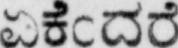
ಏಕೆಂದರೆ
